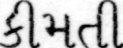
કીમતી
